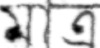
মাত্র
